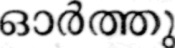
ഓര്‍ത്തു
